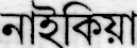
নাইকিয়া
